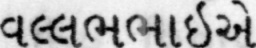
વલ્લભભાઈએ
